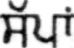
ਸੱਪਾਂ
